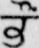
ਭੌਂ
